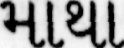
માથા
